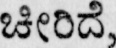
ಚೀರಿದೆ,
